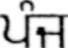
ਪੰਜ
